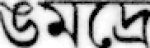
ঙমদ্রে
